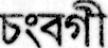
চংবগী
